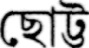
ছোট্ট
